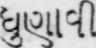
ધુણાવી
